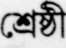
শ্রেষ্ঠী
